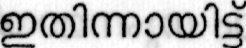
ഇതിന്നായിട്ട്
